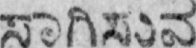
ಸಾಗಿಸುವ
